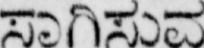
ಸಾಗಿಸುವ
